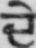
ਦੇ
